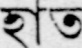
হাত
